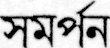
সমর্পন
